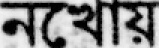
নখোয়
